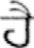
ਹੈ
